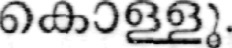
കൊള്ളൂ.
